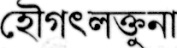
হৌগৎলক্তুনা
